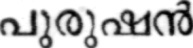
പുരുഷന്‍
